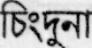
চিংদুনা
